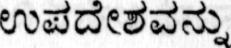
ಉಪದೇಶವನ್ನು
